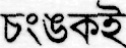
চংঙকই
